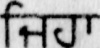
ਜਿਹਾ
